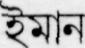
ইমান
